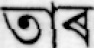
তাৰ
